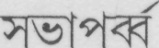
সভাপৰ্ব্ব
